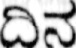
ದಿನ
